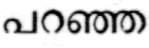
പറഞ്ഞ
